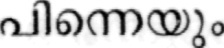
പിന്നെയും
